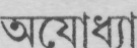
অযোধ্যা
